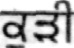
ਕੁੜੀ
